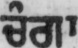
ਚੰਗਾ
